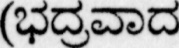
(ಭದ್ರವಾದ
